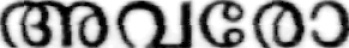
അവരോ
